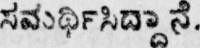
ಸಮರ್ಥಿಸಿದ್ದಾನೆ.
